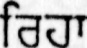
ਰਿਹਾ
